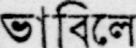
ভাবিলে
